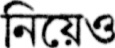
নিয়েও
